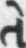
તે
